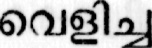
വെളിച്ച
